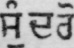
ਸੁੰਦਰੋ
